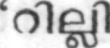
'റില്ലി
